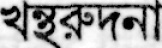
খন্থরুদনা
